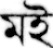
মই
